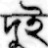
দুই
